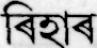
ৰিহাৰ
